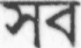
সব
